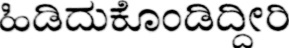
ಹಿಡಿದುಕೊಂಡಿದ್ದೀರಿ
